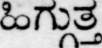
ಹಿಗ್ಗುತ್ತ
